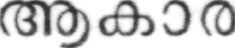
ആകാര
